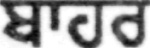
ਬਾਹਰ
